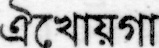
ঐখোয়গা
